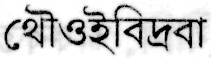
থৌওইবিদ্রবা
